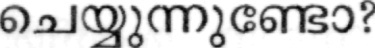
ചെയ്യുന്നുണ്ടോ?
